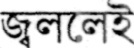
জ্বললেই
